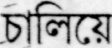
চালিয়ে
